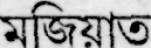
মজিয়াত
